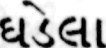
ઘડેલા
